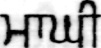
ਮਾਘੀ
